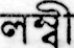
লম্বী
